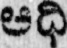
ಅಧಿ
